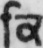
ਕਿ
